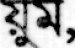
য়ুম,
